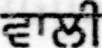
ਵਾਲੀ
